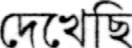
দেখেছি
